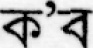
ক'ব
